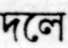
দলে
